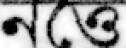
নত্তে
